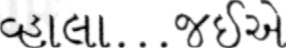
વ્હાલા...જઈએ
